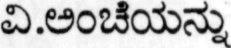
ವಿ.ಅಂಚೆಯನ್ನು
